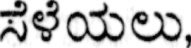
ಸೆಳೆಯಲು,
